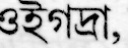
ওইগদ্রা,
